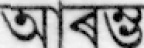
আৰম্ভ
